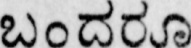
ಬಂದರೂ
